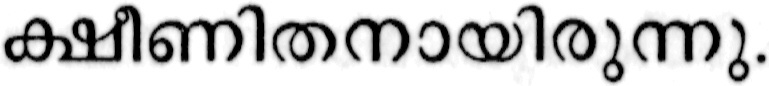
ക്ഷീണിതനായിരുന്നു.
